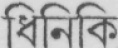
ধিনিকি
